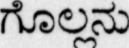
ಗೊಲ್ಲನು
